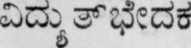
ವಿದ್ಯುತ್‌ಭೇದಕ
